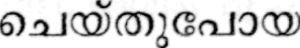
ചെയ്തുപോയ
